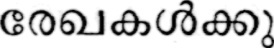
രേഖകള്‍ക്കു
